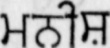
ਮਨੀਸ਼
